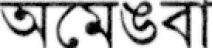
অমেঙবা
